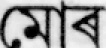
মোৰ
